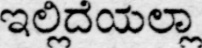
ಇಲ್ಲಿದೆಯಲ್ಲಾ
